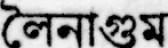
লৈনাগুম
